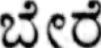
ಬೇರೆ
